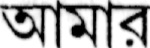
আমার
